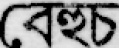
বেহুচ
